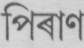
পিৰাণ
